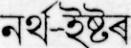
নৰ্থ-ইষ্টৰ
